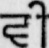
ਵੀ
